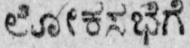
ಲೋಕಸಭೆಗೆ
